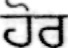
ਹੋਰ
